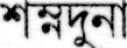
শম্নদুনা
